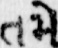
તમે
